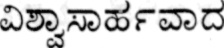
ವಿಶ್ವಾಸಾರ್ಹವಾದ
